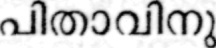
പിതാവിനു
